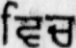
ਵਿਚ
